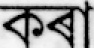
কৰা
